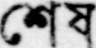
শেষ
